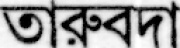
তারুবদা
